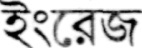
ইংরেজ
